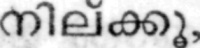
നില്ക്കൂ,
